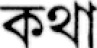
কথা
